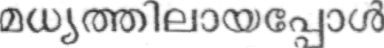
മധ്യത്തിലായപ്പോള്‍
